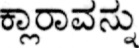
ಕ್ಲಾರಾವನ್ನು
